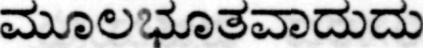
ಮೂಲಭೂತವಾದುದು
